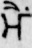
ਮੈਂ
